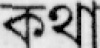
কথা
